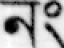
নং
